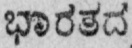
ಭಾರತದ
